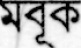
মবূক
